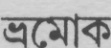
ভ্ৰমোক
